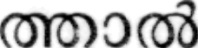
ത്താല്‍
